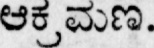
ಆಕ್ರಮಣ.
